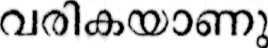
വരികയാണു
